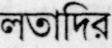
লতাদির
